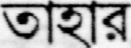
তাহার
